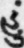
હું
